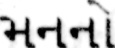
મનનો
